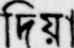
দিয়া
